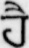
ਹੈ
